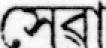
সেৱা
